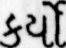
કર્યો
